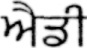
ਐਡੀ
